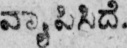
ವ್ಯಾಪಿಸಿದೆ.
